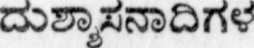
ದುಶ್ಯಾಸನಾದಿಗಳ
